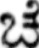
ಚೆ
